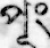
পূং
